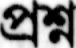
প্রশ্ন
